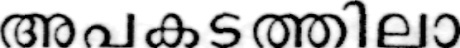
അപകടത്തിലാ
